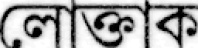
লোক্তাক
